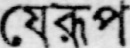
যেরূপ
